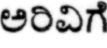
ಅರಿವಿಗೆ
